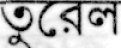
তুরেল
